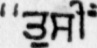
''ਤੁਸੀਂ
